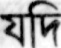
যদি
